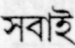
সবাই
